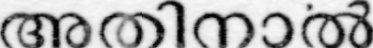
അതിനാല്‍
